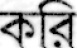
করি
